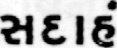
સદાહં
